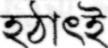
হঠাৎই
